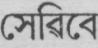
সেৱিবে
